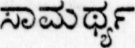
ಸಾಮರ್ಥ್ಯ
